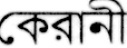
কেরানী
